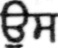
ਉਸ
